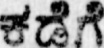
ಕಡೆಗೆ
